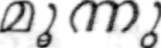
മൂന്നു
